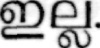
ഇല്ല.
